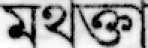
মথক্তা
